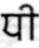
ਧੀ
